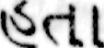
હતા
